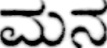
ಮನ
